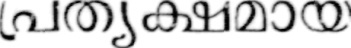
പ്രത്യക്ഷമായ
